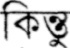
কিন্তু
